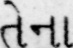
તેના
